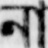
না
